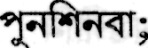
পুনশিনবা;
